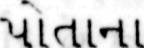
પોતાના
